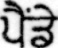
ਪੈਂਡੇ
